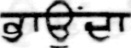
ਭਾਉਂਦਾ
